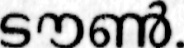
ടൌണ്‍.
